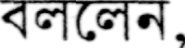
বললেন,
